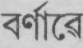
বৰ্ণাৱে
